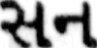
સન
